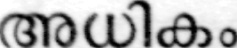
അധികം
